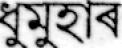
ধুমুহাৰ
